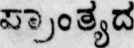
ಪ್ರಾಂತ್ಯದ
